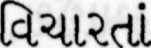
વિચારતાં
